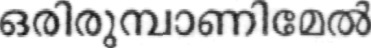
ഒരിരുമ്പാണിമേല്‍
